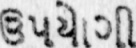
ઉપયોગી
